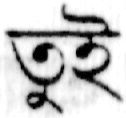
তুই
